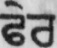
ਫੇਰ
